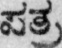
ಪತ್ರ
